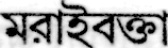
মরাইবক্তা
